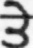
ਤੇ
